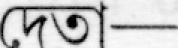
দেতা-
